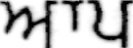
ਆਪ
